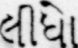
લીધો
